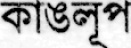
কাঙলূপ
